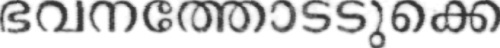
ഭവനത്തോടടുക്കെ
